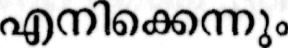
എനിക്കെന്നും
